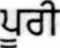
ਪੂਰੀ
